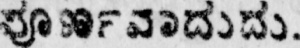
ಪೂರ್ಣವಾದುದು.
